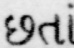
છતાં
